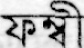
ফম্বী
